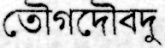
তৌগদৌবদু
